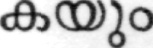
കയും
